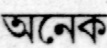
অনেক
